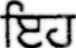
ਇਹ
